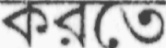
করতে
